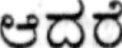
ಆದರೆ
